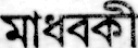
মাধবকী
